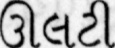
ઊલટી
